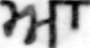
ਆ
